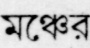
মঞ্চের
